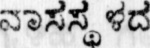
ವಾಸಸ್ಥಳದ
